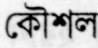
কৌশল
